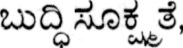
ಬುದ್ಧಿಸೂಕ್ಷ್ಮತೆ,
